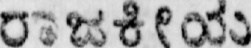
ರಾಜಕೀಯ
